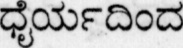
ಧೈರ್ಯದಿಂದ
